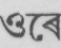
ওৰে
